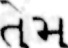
તેમ
